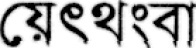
য়েৎথংবা
